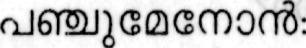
പഞ്ചുമേനോന്‍:
